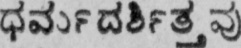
ಧರ್ಮದರ್ಶಿತ್ತವು
